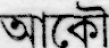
আকৌ
